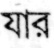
যার
